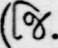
(જિ.
